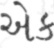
એક
